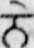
ਨੇ
